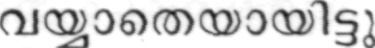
വയ്യാതെയായിട്ടു
